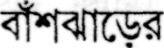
বাঁশঝাড়ের
